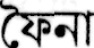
ফৈনা
